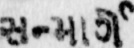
સન્માર્ગે
